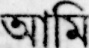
আমি
